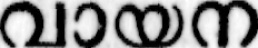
വായന
